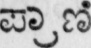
ಪ್ರಾಣಿ
